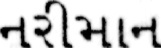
નરીમાન
